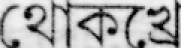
থোকখ্রে
